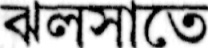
ঝলসাতে
